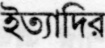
ইত্যাদির
